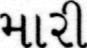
મારી
